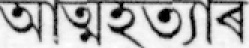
আত্মহত্যাৰ
